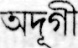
অদূগী
